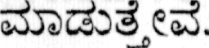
ಮಾಡುತ್ತೇವೆ.
